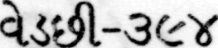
વેડછી-૩૯૪
